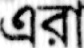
এরা
